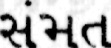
સંમત
